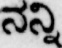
ನನ್ನಿ
